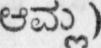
ಆಮ್ಲ)
